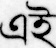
এই
